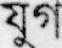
যুগ
